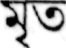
মৃত
